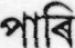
পাৰি
